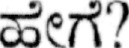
ಹೇಗೆ?
